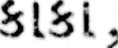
કાકાં,
